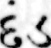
દંડ
